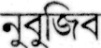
নুবুজিব
